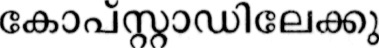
കോപ്സ്റ്റാഡിലേക്കു
